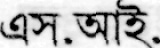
এস.আই.
